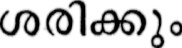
ശരിക്കും
